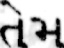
તેમ
